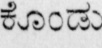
ಕೊಂಡು
